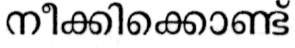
നീക്കിക്കൊണ്ട്
